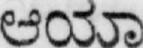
ಆಯಾ
